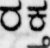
ರಕ್ತ
